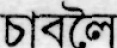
চাবলৈ
